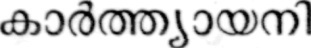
കാര്‍ത്ത്യായനി
